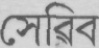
সেৱিব
